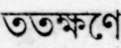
ততক্ষণে
